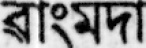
ৱাংমদা
